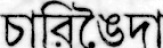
চারিঙৈদা
